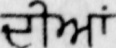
ਦੀਆਂ
